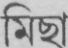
মিছা
